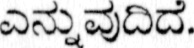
ಎನ್ನುವುದಿದೆ.
